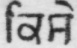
ਕਿਸੇ
